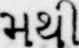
મથી
